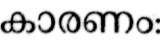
കാരണം:
